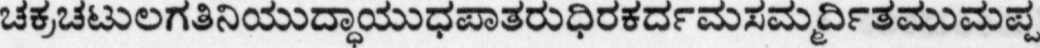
ಚಕ್ರಚಟುಲಗತಿನಿಯುದ್ಧಾಯುಧಪಾತರುಧಿರಕರ್ದಮಸಮ್ಮರ್ದಿತಮುಮಪ್ಪ
